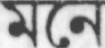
মনে
